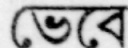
ভেবে
